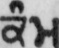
ਕੰਮ
